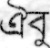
ঐবু
